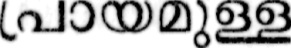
പ്രായമുള്ള
